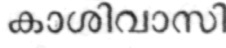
കാശിവാസി
